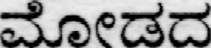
ಮೋಡದ
